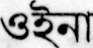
ওইনা
